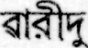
ৱারীদু
